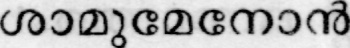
ശാമുമേനോന്‍
